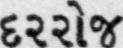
દરરોજ
